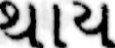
થાય
